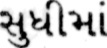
સુધીમાં
